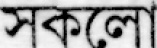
সকলো
